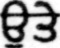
ਉਤੇ
